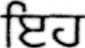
ਇਹ
